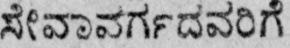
ಸೇವಾವರ್ಗದವರಿಗೆ
